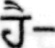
ਹੈ-
